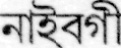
নাইবগী
